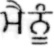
ਮੈਨੂੰ
